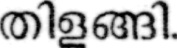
തിളങ്ങി.
